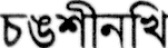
চঙশীনখি
